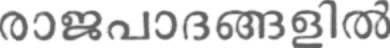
രാജപാദങ്ങളില്‍
